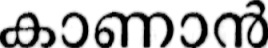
കാണാന്‍
